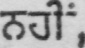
ਨਹੀਂ,
